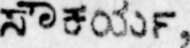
ಸೌಕರ್ಯ,
